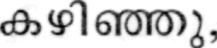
കഴിഞ്ഞു,
